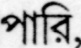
পারি,
